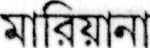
মারিয়ানা
